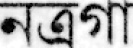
নত্রগা
